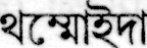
থম্মোইদা
